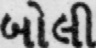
બોલી
